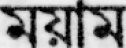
ময়াম
